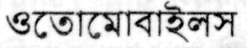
ওতোমোবাইলস
